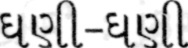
ઘણી-ઘણી
